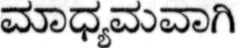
ಮಾಧ್ಯಮವಾಗಿ
